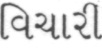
વિચારી
